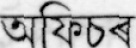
অফিচৰ
